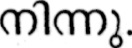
നിന്നു.
